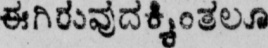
ಈಗಿರುವುದಕ್ಕಿಂತಲೂ
